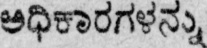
ಅಧಿಕಾರಗಳನ್ನು
